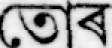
তোৰ
